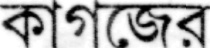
কাগজের
